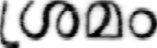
ശ്രമം
